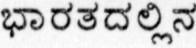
ಭಾರತದಲ್ಲಿನ
